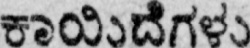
ಕಾಯಿದೆಗಳು
